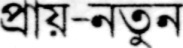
প্রায়-নতুন
